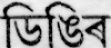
ডিঙিৰ
